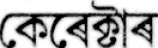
কেৰেক্টাৰ
